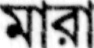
মারা
